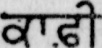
ਕਾਫ਼ੀ
